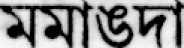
মমাঙদা
